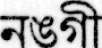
নঙগী
